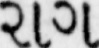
રાગ
